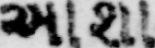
આશા
